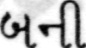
બની
